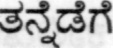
ತನ್ನೆಡೆಗೆ
